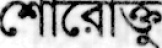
শোরোক্তু
